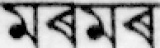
মৰমৰ
